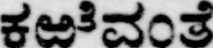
ಕಱೆವಂತೆ
